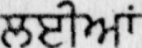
ਲਈਆਂ
